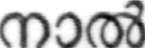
നാല്‍
